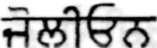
ਜੋਲੀਓਨ
